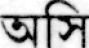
অসি
